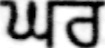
ਘਰ
